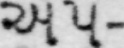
અપ-
